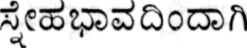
ಸ್ನೇಹಭಾವದಿಂದಾಗಿ
